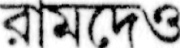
রামদেও
